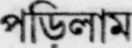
পড়িলাম
